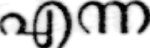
എന്ന
